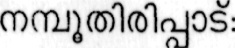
നമ്പൂതിരിപ്പാട്:
